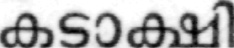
കടാക്ഷി
